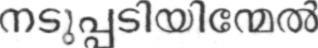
നടുപ്പടിയിന്മേല്‍
